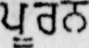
ਪੂਰਨ
